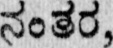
ನಂತರ,
